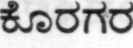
ಕೊರಗರ
